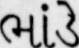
ભાંડે
